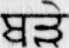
ਬੜੇ
